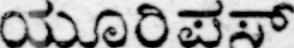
ಯೂರಿಪಸ್
